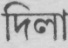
দিলা
